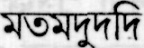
মতমদুদদি
